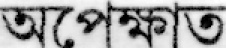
অপেক্ষাত
